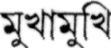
মুখামুখি
